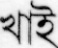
খাই
